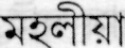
মহলীয়া
